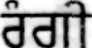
ਰੰਗੀ
